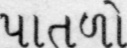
પાતળો
